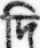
দি
